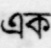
এক
